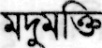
মদুমক্তি
